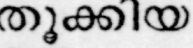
തൂക്കിയ
